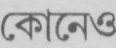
কোনেও
